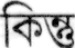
কিন্তু
